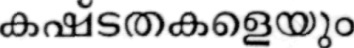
കഷ്ടതകളെയും
